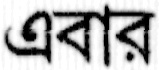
এবার
